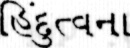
હિંદુત્વના
